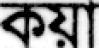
কয়া
